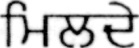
ਮਿਲਦੇ
